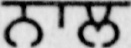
ਨਾਲ
